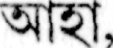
আহা,
